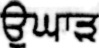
ਉਘਾੜ
